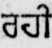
ਰਹੀ
